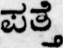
ಪತ್ತೆ
